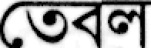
তেবল
